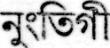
নুংতিগী
